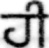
ਹੀ
